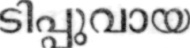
ടിപ്പുവായ
